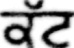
ਕੱਟ
